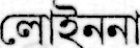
লোইননা
